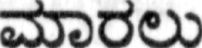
ಮಾರಲು
